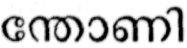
ന്തോണി
